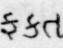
ફક્ત
